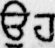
ਉਹ
